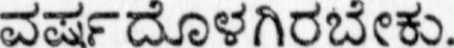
ವರ್ಷದೊಳಗಿರಬೇಕು.
